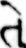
તે
